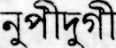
নুপীদুগী
